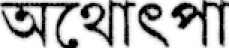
অথোৎপা
